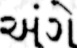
અંગે
